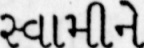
સ્વામીને
